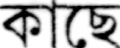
কাছে
